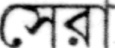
সেরা
